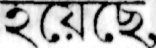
হয়েছে,
